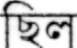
ছিল
